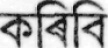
কৰিবি
